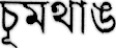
চূমথাঙ
